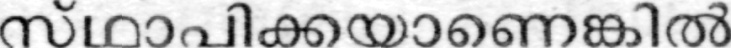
സ്ഥാപിക്കയാണെങ്കില്‍
